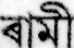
ৰামী
